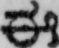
ಈ
